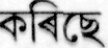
কৰিছে
